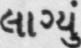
લાગ્યું
